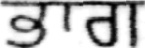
ਭਾਗ
